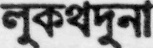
লুকথদুনা
